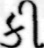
કી
